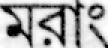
মরাং
